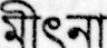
মীৎনা
